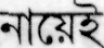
নায়েই
